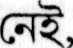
নেই,
